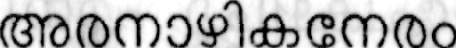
അരനാഴികനേരം
